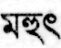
মহুৎ
